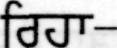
ਰਿਹਾ-
